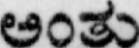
ಅಂತು
